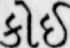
કોઈ
